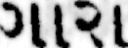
ગારા
